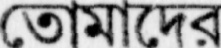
তোমাদের
